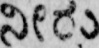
ನೀರು
